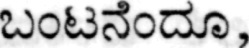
ಬಂಟನೆಂದೂ,
